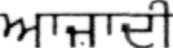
ਆਜ਼ਾਦੀ
